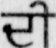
ਦੀ
